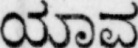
ಯಾವ
